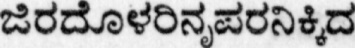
ಜಿರದೊಳರಿನೃಪರನಿಕ್ಕಿದ
